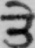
ਤੇ
